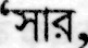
‘সার,
